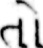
તો
